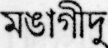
মঙাগীদু
